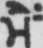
ਮੈਂ
